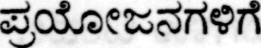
ಪ್ರಯೋಜನಗಳಿಗೆ
